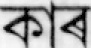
কাৰ
